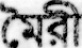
মৈরী
